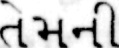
તેમની
